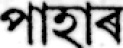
পাহাৰ
